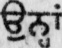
ਉਨ੍ਹਾਂ
